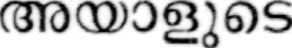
അയാളുടെ
